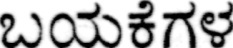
ಬಯಕೆಗಳ
